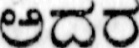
ಅದರ
